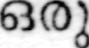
ഒരു
